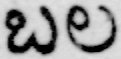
ಬಲ
